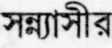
সন্ন্যাসীর
